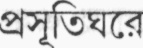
প্রসূতিঘরে
